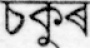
চকুৰ
